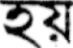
হয়
